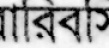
পাবুং,
